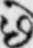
છે
